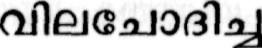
വിലചോദിച്ച
